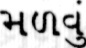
મળવું
